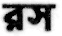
রস
